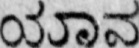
ಯಾವ
